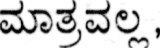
ಮಾತ್ರವಲ್ಲ,
